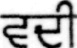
ਵਦੀ
